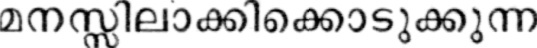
മനസ്സിലാക്കിക്കൊടുക്കുന്ന
